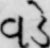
વડે
